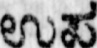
ಉಪ
